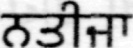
ਨਤੀਜਾ
